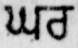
ਘਰ
